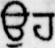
ਉਹ
